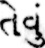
તેવું
